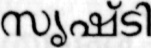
സൃഷ്ടി
